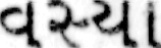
વસ્યા
